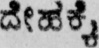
ದೇಹಕ್ಕೆ
